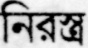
নিরস্ত্র
